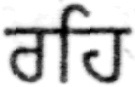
ਰਹਿ
